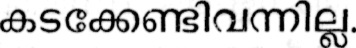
കടക്കേണ്ടിവന്നില്ല.
